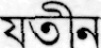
যতীন
